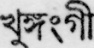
খুঙ্গংগী
